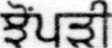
ਝੋਂਪੜੀ
